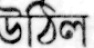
উঠিল
